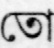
তো
